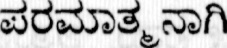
ಪರಮಾತ್ಮನಾಗಿ
